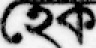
হেক
